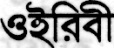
ওইরিবী
